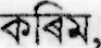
কৰিম,
